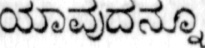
ಯಾವುದನ್ನೂ
